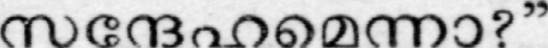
സന്ദേഹമെന്നാ?"
